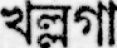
খল্লগা
